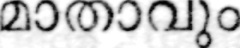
മാതാവും
